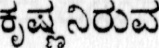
ಕೃಷ್ಣನಿರುವ
